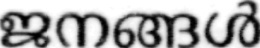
ജനങ്ങള്‍
